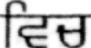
ਵਿਚ
